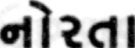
નોરતા
